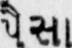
પૈસા
